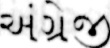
અંગ્રેજી
